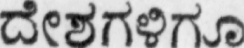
ದೇಶಗಳಿಗೂ
